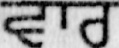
ਵਾਰ
